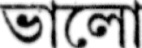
ভালো
